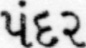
પંદર
